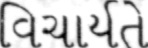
વિચાર્યતે
